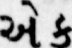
એક
